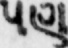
પણ
